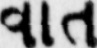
વાત
